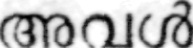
അവള്‍
